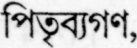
পিতৃব্যগণ,
